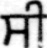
ਸੀ
